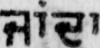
ਜਾਂਦਾ
